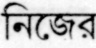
নিজের
